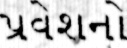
પ્રવેશનો
